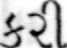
કરી
